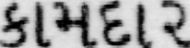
કામદાર
